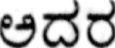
ಅದರ
